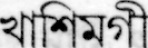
খাশিমগী
